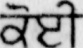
ਕੋਈ
